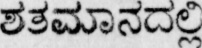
ಶತಮಾನದಲ್ಲಿ
